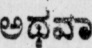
ಅಥವಾ
